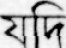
যদি
